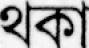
থকা
